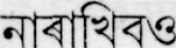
নাৰাখিবও
